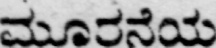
ಮೂರನೆಯ
